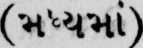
(મધ્યમાં)
